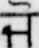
ਜੋ
